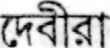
দেবীরা
